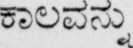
ಕಾಲವನ್ನು
